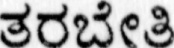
ತರಬೇತಿ
